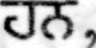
ਹਨ,
